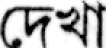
দেখা
